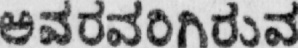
ಅವರವರಿಗಿರುವ
